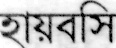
হায়বসি
